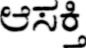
ಆಸಕ್ತಿ
